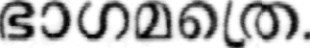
ഭാഗമത്രെ.
